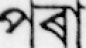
পৰা
